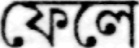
ফেলে
